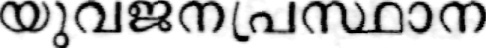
യുവജനപ്രസ്ഥാന
